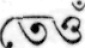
তেওঁ
